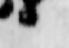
જ
